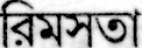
রিমসতা
